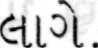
લાગે.
